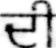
ਦੀ
